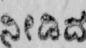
ನೀಡಿದ
